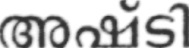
അഷ്ടി
